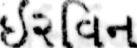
ઇરવિન
